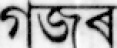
গজৰ
